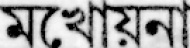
মখোয়না
